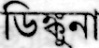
ডিঙ্কুনা
